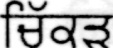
ਚਿੱਕੜ
